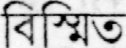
বিস্মিত
